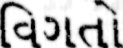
વિગતો
